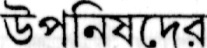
উপনিষদের
